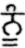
ਨੂੰ
